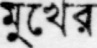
মুখের
